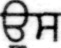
ਉਸ
